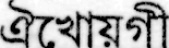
ঐখোয়গী
